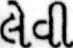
લેવી
